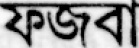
ফজবা
